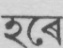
হৰে
